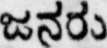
ಜನರು
